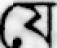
যে
